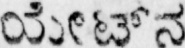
ಯೇಟ್‌ನ
